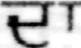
ਦਾ
